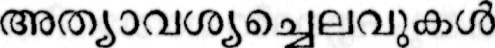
അത്യാവശ്യച്ചെലവുകള്‍
